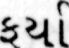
ફર્યા
